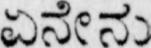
ಏನೇನು
